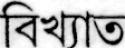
বিখ্যাত
